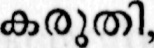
കരുതി,
